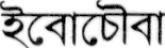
ইবোচৌবা
